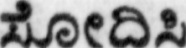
ಸೋದಿಸಿ
